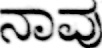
ನಾವು
